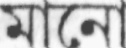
মানো
